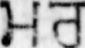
ਮਰ
